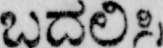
ಬದಲಿಸಿ
